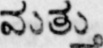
ಮತ್ತು
